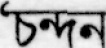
'চন্দন
